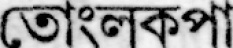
তোংলকপা
